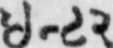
ઇન્ટર
